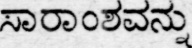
ಸಾರಾಂಶವನ್ನು
